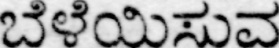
ಬೆಳೆಯಿಸುವ
